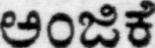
ಅಂಜಿಕೆ
